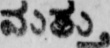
ಮತ್ತು
